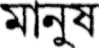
মানুষ
